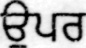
ਉਪਰ
